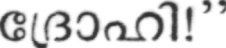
ദ്രോഹി!"
